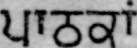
ਪਾਠਕਾਂ
